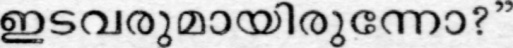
ഇടവരുമായിരുന്നോ?"
